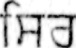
ਸਿਰ
